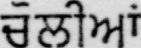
ਚੋਲੀਆਂ
